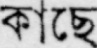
কাছে
